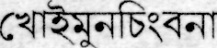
খোইমুনচিংবনা
